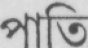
পাতি
